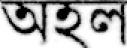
অহল
